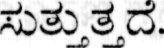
ಸುತ್ತುತ್ತದೆ.
